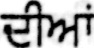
ਦੀਆਂ
